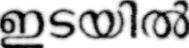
ഇടയില്‍
